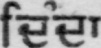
ਦਿੰਦਾ
